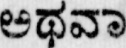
ಅಥವಾ
